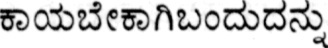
ಕಾಯಬೇಕಾಗಿಬಂದುದನ್ನು
